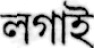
লগাই
